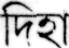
দিহা
